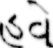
હવે
